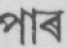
পাৰ
